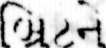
બ્રિટને
